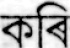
কৰি
